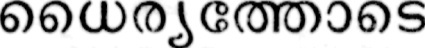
ധൈര്യത്തോടെ
